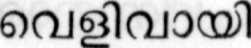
വെളിവായി
